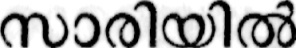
സാരിയില്‍
